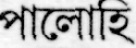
পালোহি
